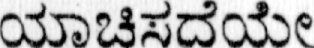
ಯಾಚಿಸದೆಯೇ
